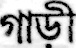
গাড়ী
